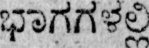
ಭಾಗಗಳಲ್ಲಿ
